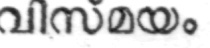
വിസ്മയം
